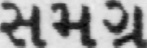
સમગ્ર
